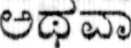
ಅಥವಾ
